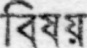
বিষয়
